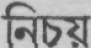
নিচয়
